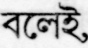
বলেই,
